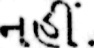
નહીં.
